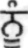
ਨੂੰ
